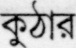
কুঠার
